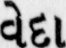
વેદા
